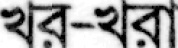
খর-খর
